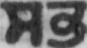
ਸਭ
